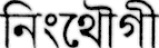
নিংথৌগী
